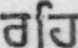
ਰਹਿ
